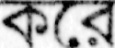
করে
